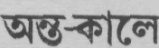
অন্ত-কালে
